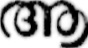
ആ
